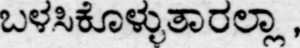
ಬಳಸಿಕೊಳ್ಳುತಾರಲ್ಲಾ,
